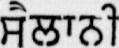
ਸੈਲਾਨੀ
